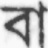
বা
